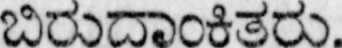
ಬಿರುದಾಂಕಿತರು.
